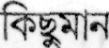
কিছুমান
